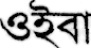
ওইবা
